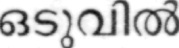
ഒടുവില്‍
